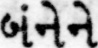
બંનેને
